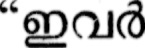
“ഇവര്‍
